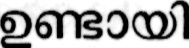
ഉണ്ടായി
